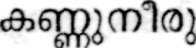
കണ്ണുനീരു
